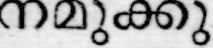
നമുക്കു
